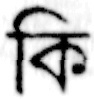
কি
